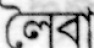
লৈবা
